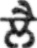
ਲੈ
